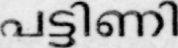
പട്ടിണി
